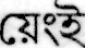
য়েংই
